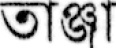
তাঞ্জা
